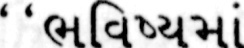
"ભવિષ્યમાં
